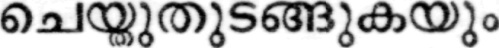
ചെയ്തുതുടങ്ങുകയും
